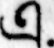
এ.
